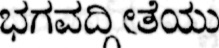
ಭಗವದ್ಗೀತೆಯು
